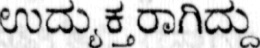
ಉದ್ಯುಕ್ತರಾಗಿದ್ದು
